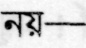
নয়–
